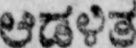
ಆಡಳಿತ
